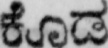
ಕೊಡ
